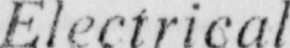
Electrical
